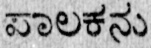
ಪಾಲಕನು
